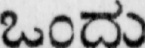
ಒಂದು
